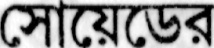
সোয়েডের
